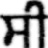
ਸੀ
